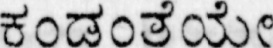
ಕಂಡಂತೆಯೇ
